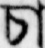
চা
